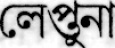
লেপ্তুনা
